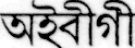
অইবীগী
